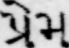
પ્રેમ
